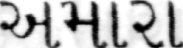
અમારા
